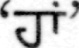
'ਹਾਂ'
